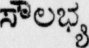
ಸೌಲಭ್ಯ
